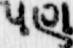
પણ
